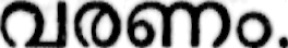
വരണം.
